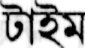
টাইম
